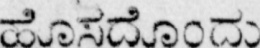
ಹೊಸದೊಂದು
